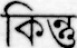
কিন্তু
